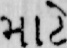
માટે
